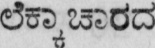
ಲೆಕ್ಕಾಚಾರದ
